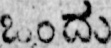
ಒಂದು
